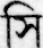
সি
